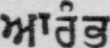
ਆਰੰਭ
